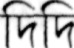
দিদি
